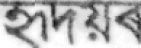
হৃদয়ৰ
